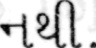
નથી.
